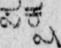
ಪಕ್ಷ
